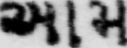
આમ
